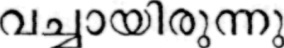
വച്ചായിരുന്നു
